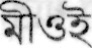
মীওই
